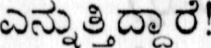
ಎನ್ನುತ್ತಿದ್ದಾರೆ!
